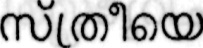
സ്ത്രീയെ
